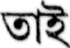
তাই
